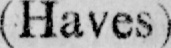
(Haves)
